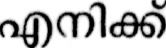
എനിക്ക്
